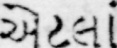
એટલાં
